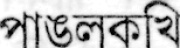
পাঙলকখি
